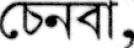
চেনবা,
